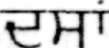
ਦਸਾਂ
